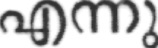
എന്നു
